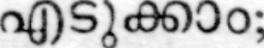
എടുക്കാം;
